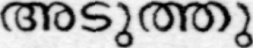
അടുത്തു
